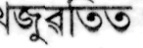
খজুৱতিত
